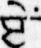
ਏਂ
